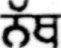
ਨੱਥ
